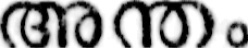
അന്തം
